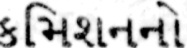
કમિશનનો
